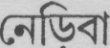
নেড়িবা
